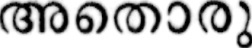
അതൊരു
